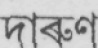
দাৰুণ
